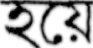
হয়ে
